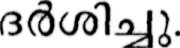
ദര്‍ശിച്ചു.
